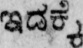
ಇದಕ್ಕೆ
